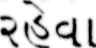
રહેવા
